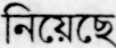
নিয়েছে
